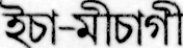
ইচা-মীচাগী
